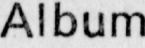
Album
